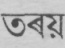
তৰয়
